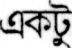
একটু
